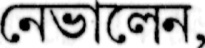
নেভালেন,
